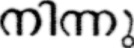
നിന്നു
